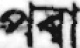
পৰা
